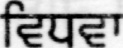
ਵਿਧਵਾ
